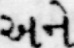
અને
